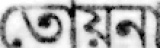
তোয়না
